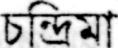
চন্দ্রিমা
